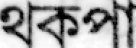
থকপা
